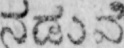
ನಡುವೆ
